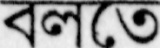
বলতে
